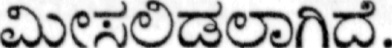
ಮೀಸಲಿಡಲಾಗಿದೆ.
